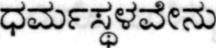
ಧರ್ಮಸ್ಥಳವೇನು
